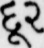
દૂર
